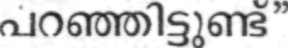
പറഞ്ഞിട്ടുണ്ട്”
